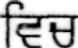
ਵਿਚ
